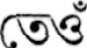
তেওঁ
